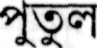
পুতুল
